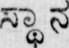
ಸ್ಥಾನ
